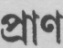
প্ৰাণ
